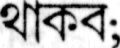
থাকব;
